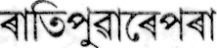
ৰাতিপুৱাৰেপৰা
